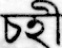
চহী
